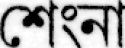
শেংনা
